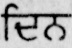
ਦਿਨ
